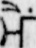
ਮੈਂ
